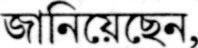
জানিয়েছেন,
